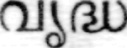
വൃദ്ധ
